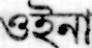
ওইনা
